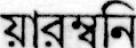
য়ারম্বনি
